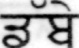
ਡੱਬੇ
